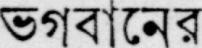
ভগবানের
